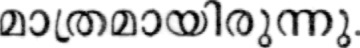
മാത്രമായിരുന്നു.
